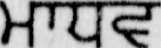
ਮਾਧਵ
